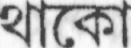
থাকো
